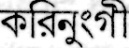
করিনুংগী
